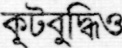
কূটবুদ্ধিও
